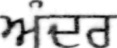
ਅੰਦਰ
